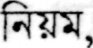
নিয়ম,
